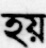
হয়
